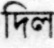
দিল
